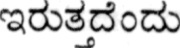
ಇರುತ್ತದೆಂದು
